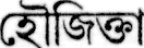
হৌজিক্তা
